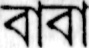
বাবা
